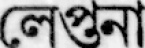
লেপ্তনা
